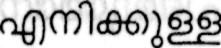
എനിക്കുള്ള
